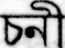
চনী
